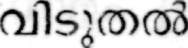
വിടുതല്‍
